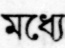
মধ্যে
